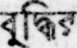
বুদ্ধির
